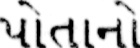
પોતાનો
